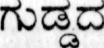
ಗುಡ್ಡದ
